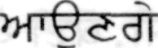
ਆਉਣਗੇ
